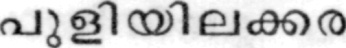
പുളിയിലക്കര
